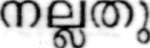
നല്ലതു
